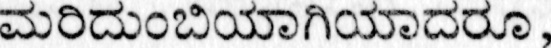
ಮರಿದುಂಬಿಯಾಗಿಯಾದರೂ,
